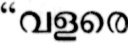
“വളരെ
